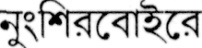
নুংশিরবোইরে
